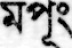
মপূং
